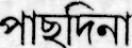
পাছদিনা
